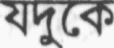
যদুকে
